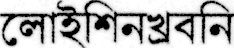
লোইশিনখ্রবনি
